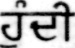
ਹੁੰਦੀ
